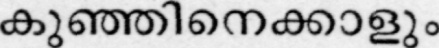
കുഞ്ഞിനെക്കാളും
